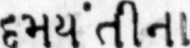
દમયંતીના
